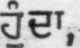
ਹੁੰਦਾ,
